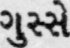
ગુસ્સે
